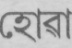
হোৱা
